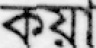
কয়া
